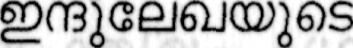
ഇന്ദുലേഖയുടെ
